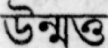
উন্মত্ত
